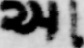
આ
